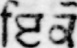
ਇਕੋ
